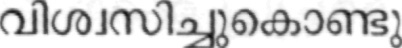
വിശ്വസിച്ചുകൊണ്ടു
